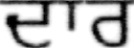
ਦਾਰ
